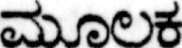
ಮೂಲಕ
